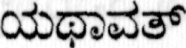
ಯಥಾವತ್
